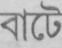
বাটে
